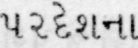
પરદેશના
